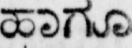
ಹಾಗೂ
